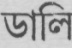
ডালি
